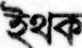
ইথক
